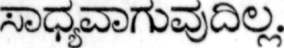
ಸಾಧ್ಯವಾಗುವುದಿಲ್ಲ.
